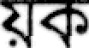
য়ক
